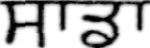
ਸਾਡਾ
